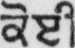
ਕੋਈ
